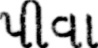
પીવા
